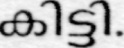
കിട്ടി.
